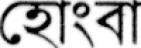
হোংবা
